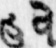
હવે
